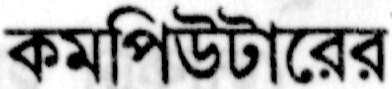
কমপিউটারের
